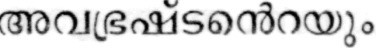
അവഭ്രഷ്ടന്റെയും
